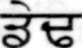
ਡੇਢ
